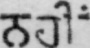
ਨਹੀਂ
